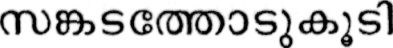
സങ്കടത്തോടുകൂടി
